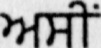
ਅਸੀਂ
